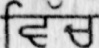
ਵਿੱਚ
